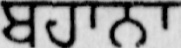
ਬਹਾਨਾ
